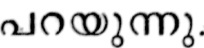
പറയുന്നു.
